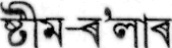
ষ্টীম-ৰ'লাৰ
